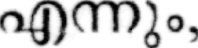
എന്നും,
